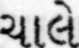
ચાલે
